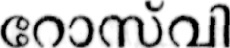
റോസ്വി
